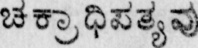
ಚಕ್ರಾಧಿಪತ್ಯವು
